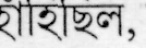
হাঁহিছিল,
